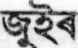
জুইৰ
